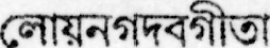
লোয়নগদবগীতা
